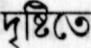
দৃষ্টিতে
